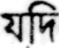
যদি
